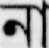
না
